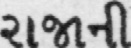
રાજાની
